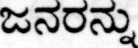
ಜನರನ್ನು
